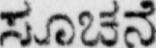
ಸೂಚನೆ
